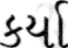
કર્યા
